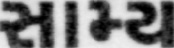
સામ્ય
